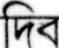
দিব
